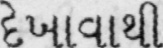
દેખાવાથી
